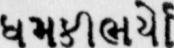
ધમકીભર્યો
